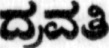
ದ್ರವತಿ
